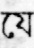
যে
